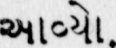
આવ્યો.
